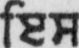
ਇਸ
